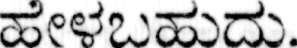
ಹೇಳಬಹುದು.
